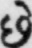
છે
